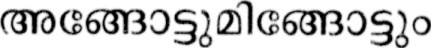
അങ്ങോട്ടുമിങ്ങോട്ടും
